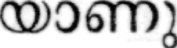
യാണു
